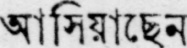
আসিয়াছেন
